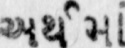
અર્થમાં
